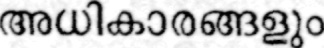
അധികാരങ്ങളും
